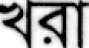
খার
